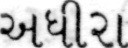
અધીરા
